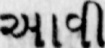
આવી
